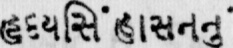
હ્રદયસિંહાસનનું
